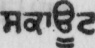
ਸਕਾਊਟ
